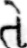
તે
